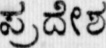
ಪ್ರದೇಶ
